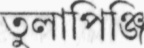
তুলাপিঞ্জি
